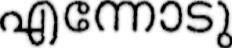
എന്നോടു
